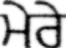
ਮੇਰੇ
